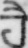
ਹੈ
